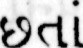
છતાં
